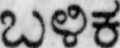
ಬಳಿಕ
